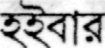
হইবার
